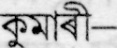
কুমাৰী-
